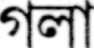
গলা
